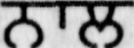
ਨਾਲ
